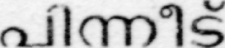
പിന്നീട്
